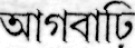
আগবাঢ়ি
